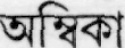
অম্বিকা
